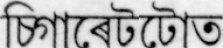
চিগাৰেটটোত
